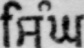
ਸਿੰਘ
